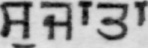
ਸੁਜਾਤਾ
